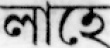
লাহে
